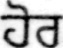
ਹੋਰ
